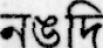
নঙদি
